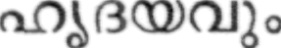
ഹൃദയവും
